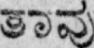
ತಾವು
